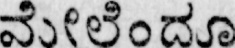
ಮೇಲೆಂದೂ
